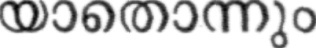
യാതൊന്നും
